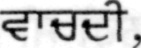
ਵਾਚਦੀ,
